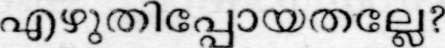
എഴുതിപ്പോയതല്ലേ?
